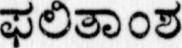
ಫಲಿತಾಂಶ
